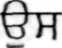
ਉਸ
